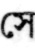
সে
